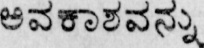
ಅವಕಾಶವನ್ನು
